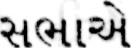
સભાએ
